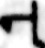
ન
